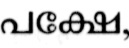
പക്ഷേ,
